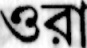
ওরা
